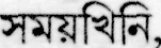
সময়খিনি,
